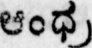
ಆಂಧ್ರ
